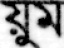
য়ুম
